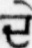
ਦੇ
